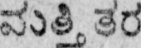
ಮತ್ತಿತರ
